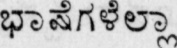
ಭಾಷೆಗಳೆಲ್ಲಾ
